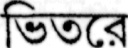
ভিতরে
